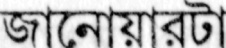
জানোয়ারটা
